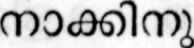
നാക്കിനു
